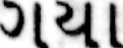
ગયા
